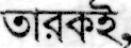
তারকই,
